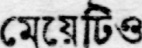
মেয়েটিও
